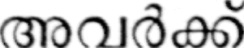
അവര്‍ക്ക്
